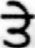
ਤੇ
